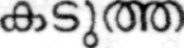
കടുത്ത
